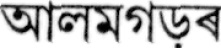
আলমগড়ৰ
